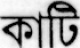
কাটি
